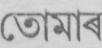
তোমাৰ
